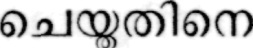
ചെയ്തതിനെ
